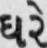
ઘરે
